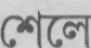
শেলে
